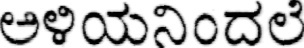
ಅಳಿಯನಿಂದಲೆ
